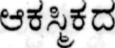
ಆಕಸ್ಮಿಕದ
